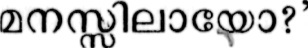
മനസ്സിലായോ?’
